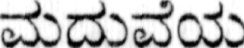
ಮದುವೆಯ
